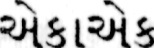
એકાએક
